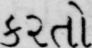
કરતો
